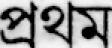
প্রথম
